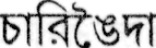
চারিঙৈদা
